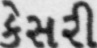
કેસરી
